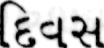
દિવસ
